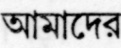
আমাদের
